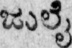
ಜುಲೈ
